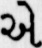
એ
